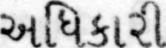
અધિકારી
